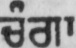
ਚੰਗਾ
